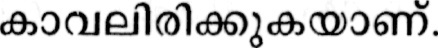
കാവലിരിക്കുകയാണ്.
